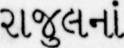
રાજુલનાં
